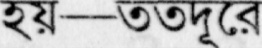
হয়-ততদূরে
